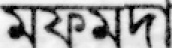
মফমদা
